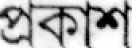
প্রকাশ
